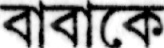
বাবাকে
